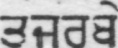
ਤਜਰਬੇ
